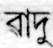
ৱাদু
